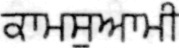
ਕਾਮਸੁਆਮੀ
